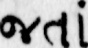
જતાં
